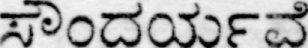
ಸೌಂದರ್ಯವೆ
